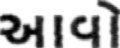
આવો......
